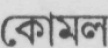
কোমল
